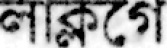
লাক্লগে
